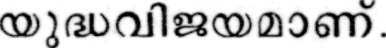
യുദ്ധവിജയമാണ്.
